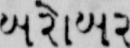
બરોબર
